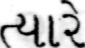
ત્યારે
